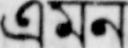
এমন
